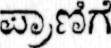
ಪ್ರಾಣಿಗೆ
